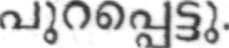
പുറപ്പെട്ടു.
